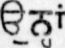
ਉਨ੍ਹਾਂ
